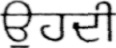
ਉਹਦੀ
